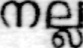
നല്ല
